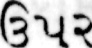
ઉપર
